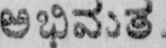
ಅಭಿಮತ.
